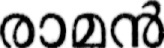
രാമന്‍
